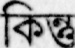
কিন্তু
